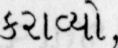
કરાવ્યો,
